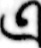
এ
